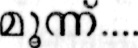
മൂന്ന്...
